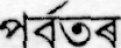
পর্বতৰ
